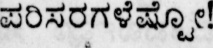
ಪರಿಸರಗಳೆಷ್ಟೋ!
